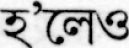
হ'লেও
